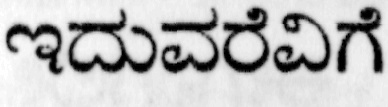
ಇದುವರೆವಿಗೆ
